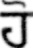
ਹੋ
